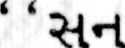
"સન
